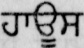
ਹਾਊਸ
